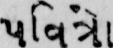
પવિત્રો
